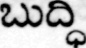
ಬುದ್ಧಿ
